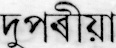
দুপৰীয়া
